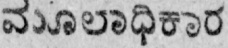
ಮೂಲಾಧಿಕಾರ
